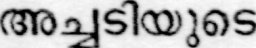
അച്ചടിയുടെ
